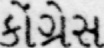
કોંગ્રેસ
